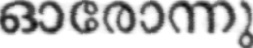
ഓരോന്നു
